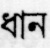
ধান
